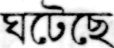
ঘটেছে
